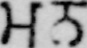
ਮਨ
